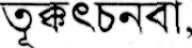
তূক্কৎচনবা,
